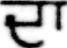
ਦਾ
